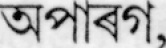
অপাৰগ,
